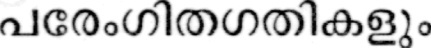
പരേംഗിതഗതികളും
